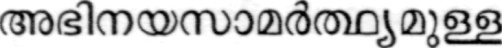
അഭിനയസാമാര്‍ത്ഥ്യമുള്ള
